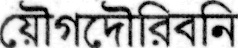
য়ৌগদৌরিবনি
